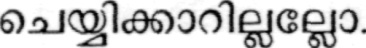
ചെയ്യിക്കാറില്ലല്ലോ.
